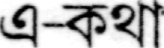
এ-কথা
